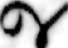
જ
